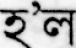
হ'ল
